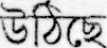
উঠিছে
